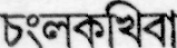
চংলকখিবা
